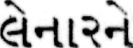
લેનારને
